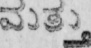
ಮತ್ತು
